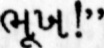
ભૂખ!"
